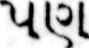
પણ
